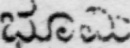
ಭೂಮಿ
